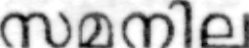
സമനില
